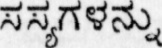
ಸಸ್ಯಗಳನ್ನು
